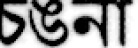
চঙনা
